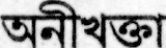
অনীখক্তা
